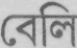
বেলি
